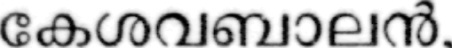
കേശവബാലന്‍,
